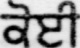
ਕੋਈ
